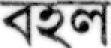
বহল
